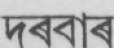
দৰবাৰ
